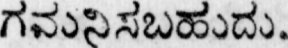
ಗಮನಿಸಬಹುದು.
